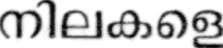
നിലകളെ
